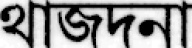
থাজদনা
